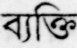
ব্যক্তি
